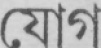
যোগ
